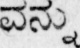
ವನ್ನು
